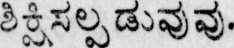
ಶಿಕ್ಷಿಸಲ್ಪಡುವುವು.
